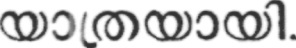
യാത്രയായി.
